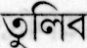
তুলিব
